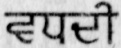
ਵਧਦੀ
